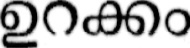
ഉറക്കം
